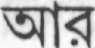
আর
